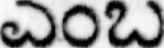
ಎಂಬ
